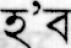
হ'ব
